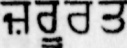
ਜ਼ਰੂਰਤ
